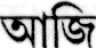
আজি
